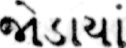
જોડાયાં
